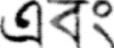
এবং
